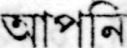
আপনি
